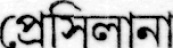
প্রেসিলানা
